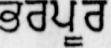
ਭਰਪੂਰ
